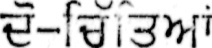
ਦੋ-ਚਿੱਤਿਆਂ
